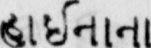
હાઈનાના
